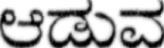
ಆಡುವ
